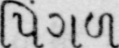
પિંગળ
